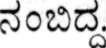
ನಂಬಿದ್ದ.
